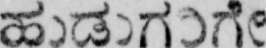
ಹುಡುಗರಿಗೇ
